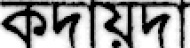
কদায়দা
